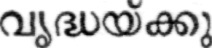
വൃദ്ധയ്ക്കു
